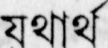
যথার্থ
